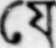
যে
